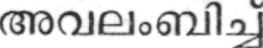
അവലംബിച്ച്
